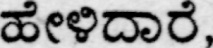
ಹೇಳಿದಾರೆ,
